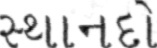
સ્થાનદો
